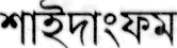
শাইদাংফম
